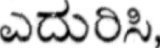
ಎದುರಿಸಿ,
